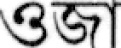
ওজা
